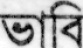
ভাবি
